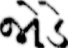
જોડે
